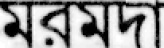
মরমদা
